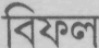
বিফল
